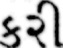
કરી
